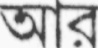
আর
